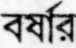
বর্ষার
